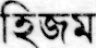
হিজম
